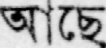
আছে
